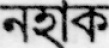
নহাক
